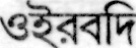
ওইরবদি
